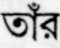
তাঁর
